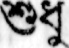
শুধু
